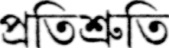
প্রতিশ্রুতি
